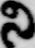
ನಿ
